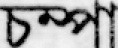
চম্পা
